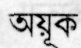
অয়ুক
